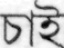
চাই
